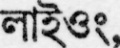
লাইওং,
